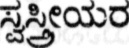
ಸ್ವಸ್ತ್ರೀಯರ
